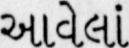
આવેલાં
